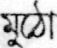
মুঠো
